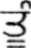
ਤੂੰ
